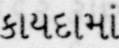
કાયદામાં
